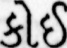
કોઈ
